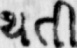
થતી
